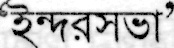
‘ইন্দরসভা’
